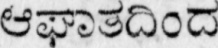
ಆಘಾತದಿಂದ
